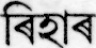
ৰিহাৰ
